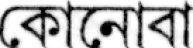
কোনোবা
